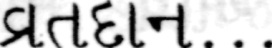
વ્રતદાન...
